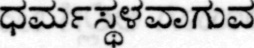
ಧರ್ಮಸ್ಥಳವಾಗುವ
